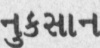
નુકસાન
